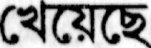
খেয়েছে
